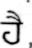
ਹੈ,
